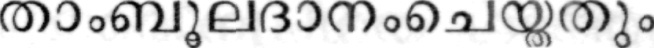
താംബൂലദാനംചെയ്തതും
